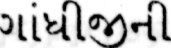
ગાંધીજીની
